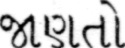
જાણતો
